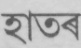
হাতৰ
